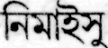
নিমাইসু
